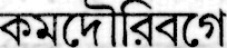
কমদৌরিবগে
